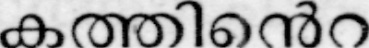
കത്തിന്റെ
